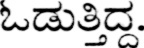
ಓಡುತ್ತಿದ್ದ.
